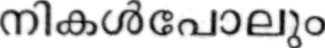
നികള്‍പോലും
